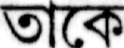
তাকে
